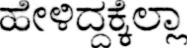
ಹೇಳಿದ್ದಕ್ಕೆಲ್ಲಾ
